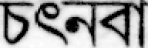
চৎনবা
